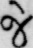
જે
